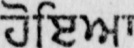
ਹੋਇਆ
